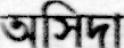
অসিদা
